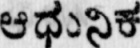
ಆಧುನಿಕ
